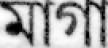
মাগা
